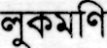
লুকমণি
